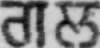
ਗਲ
